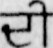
ਦੀ
